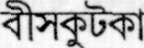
বীসকুটকা
